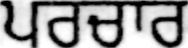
ਪਰਚਾਰ
